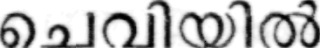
ചെവിയില്‍
